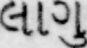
લાગુ
